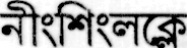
নীংশিংলক্লে
